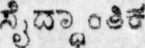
ಸೈದ್ಧಾಂತಿಕ
